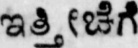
ಇತ್ತೀಚೆಗೆ
